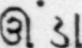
ઊંડા
